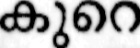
കുറെ
